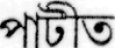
পাটীত
